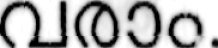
വരാം.
